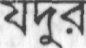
যদুর
